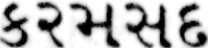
કરમસદ
